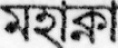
মহাক্না
